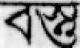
বস্তু
